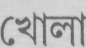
খোলা
